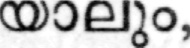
യാലും,
